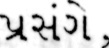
પ્રસંગે,
